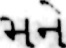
મને
